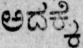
ಅದಕ್ಕೆ
